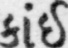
કાંઈ
